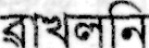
ৱাখলনি
